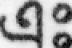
এঃ
